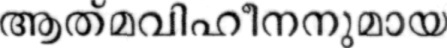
ആത്മവിഹീനനുമായ
